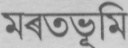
মৰতভূমি
